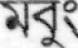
মবুং
